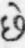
છે
